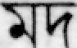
মদ
